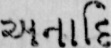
અનાદિ
